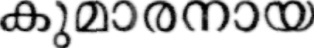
കുമാരനായ
